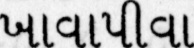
ખાવાપીવા
